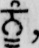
ਨੂੰ,
